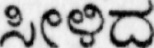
ಸೀಳಿದ
